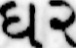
ઘર
